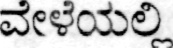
ವೇಳೆಯಲ್ಲಿ
